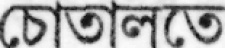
চোতালতে
